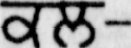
ਕਲ-
